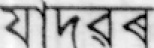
যাদৱৰ
